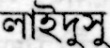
লাইদুসু
